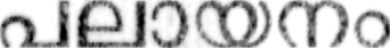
പലായനം
